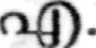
എ.
